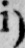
i)
